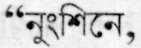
“নুংশিনে,
